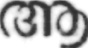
ആ
